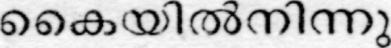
കൈയില്‍നിന്നു
